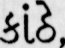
કાંઠે,
